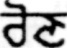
ਰੋਣ
